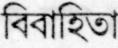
বিবাহিতা
